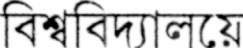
বিশ্ববিদ্যালয়ে
